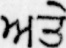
ਅਤੇ
